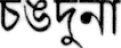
চঙদুনা
